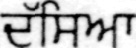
ਦੱਸਿਆ
